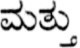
ಮತ್ತು
